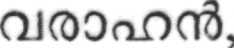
വരാഹന്‍,
